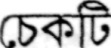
চেকটি
